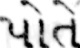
પોતે
